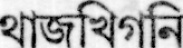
থাজখিগনি
